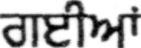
ਗਈਆਂ
